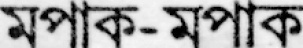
মপাক-মপাক
